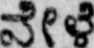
ವೇಳೆ
